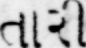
તારી
